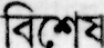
বিশেষ
